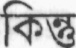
কিন্তু
